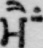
ਮੈਂ
